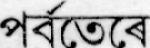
পর্বতেৰে
